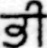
ਭੀ
